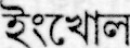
ইংখোল
